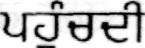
ਪਹੁੰਚਦੀ
